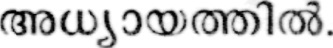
അധ്യായത്തില്‍.
